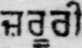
ਜ਼ਰੂਰੀ
